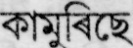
কামুৰিছে
